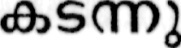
കടന്നു
